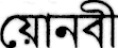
শোইদোন
